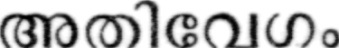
അതിവേഗം
